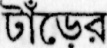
টাঁড়ের
